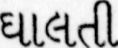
ઘાલતી
